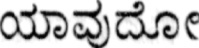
ಯಾವುದೋ
